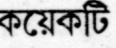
কয়েকটি
